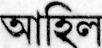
আহিল
